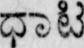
ಧಾಟಿ
